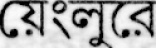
য়েংলুরে
